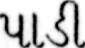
પાડી
